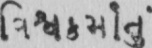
વિશ્વકર્માનું
